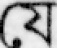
যে
